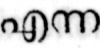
എന്ന
